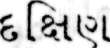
દક્ષિણ
